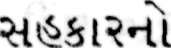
સહકારનો
